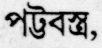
পট্টবস্ত্র,
